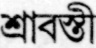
শ্রাবস্তী
